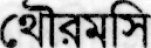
থৌরমসি
